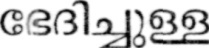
ഭേദിച്ചുള്ള
